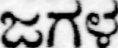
ಜಗಳ
